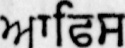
ਆਫਿਸ
